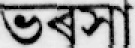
ভৰসা
